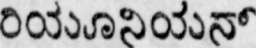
ರಿಯೂನಿಯನ್
